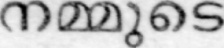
നമ്മുടെ
